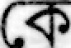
কে
